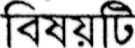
বিষয়টি
